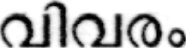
വിവരം
